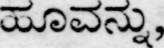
ಹೂವನ್ನು,
